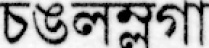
চঙলম্লগা
